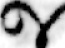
જ
